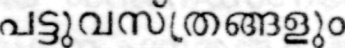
പട്ടുവസ്ത്രങ്ങളും
